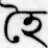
হৈ
